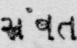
સંવત
